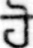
ਹੋ
